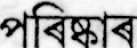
পৰিষ্কাৰ
